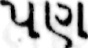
પણ
